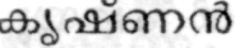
കൃഷ്ണന്‍
